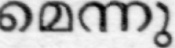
മെന്നു
